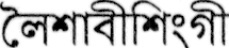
লৈশাবীশিংগী
